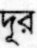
দূর
